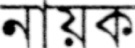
নায়ক
